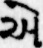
એ
